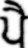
ਪੈ
